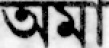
অমা
